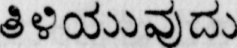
ತಿಳಿಯುವುದು
